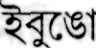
ইবুঙো
